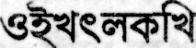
ওইখৎলকখি
